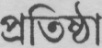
প্ৰতিষ্ঠা
